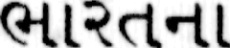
ભારતના
